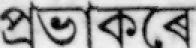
প্রভাকৰে
